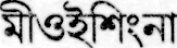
মীওইশিংনা
